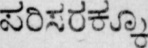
ಪರಿಸರಕ್ಕೂ
